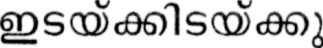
ഇടയ്ക്കിടയ്ക്കു
